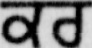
ਕਰ
